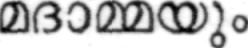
മദാമ്മയും
